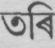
তৰি
